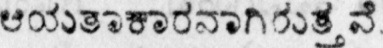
ಆಯತಾಕಾರವಾಗಿರುತ್ತವೆ.
